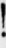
બેટા!
